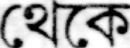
থেকে
